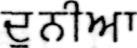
ਦੁਨੀਆ
